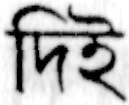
দিই
